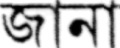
জানা
